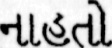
નાહતો
